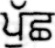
ਪੁੱਛ
